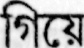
গিয়ে
